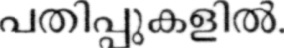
പതിപ്പുകളില്‍.
